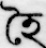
হৈ
